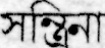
সন্ত্রিনা
